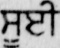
ਸੂਈ
